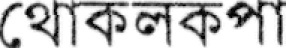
থোকলকপা
